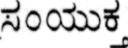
ಸಂಯುಕ್ತ
